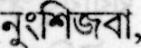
নুংশিজবা,
